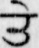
ਤੇ
